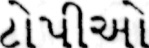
ટોપીઓ
